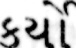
કર્યો
